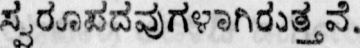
ಸ್ವರೂಪದವುಗಳಾಗಿರುತ್ತವೆ.
